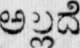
ಅಲ್ಲದೆ
